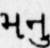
મનુ
